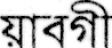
য়াবগী
